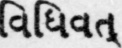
વિધિવત્
